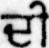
ਦੀ
